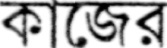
কাজের
